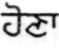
ਹੋਣਾ
